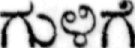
ಗುಳಿಗೆ
